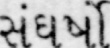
સંઘર્ષો
